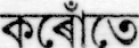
কৰোঁতে
